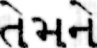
તેમને
